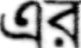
এর
